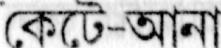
কেটে-আনা
